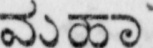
ಮಹಾ
